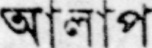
আলাপ
